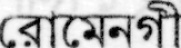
রোমেনগা
